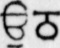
ਉਠ
